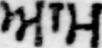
ਆਮ
